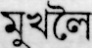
মুখলৈ
